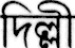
দিল্লী
